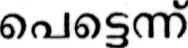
പെട്ടെന്ന്
